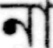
না
